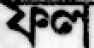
ফল
